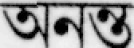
অনন্ত
